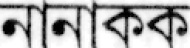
নানাকক
